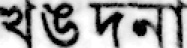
খঙদনা
